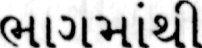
ભાગમાંથી
